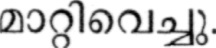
മാറ്റിവെച്ചു.
